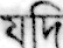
যদি
